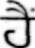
ਹੈਂ
